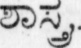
ಶಾಸ್ತ್ರ,
